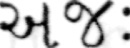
અજઃ
